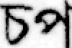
চপ
